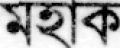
মহাক
